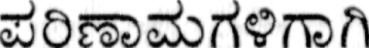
ಪರಿಣಾಮಗಳಿಗಾಗಿ
